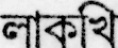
লাকখি
